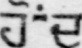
ਹੋਂਦ
